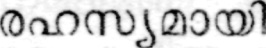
രഹസ്യമായി
